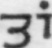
ਤਾਂ
